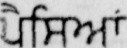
ਪੈਸਿਆਂ
